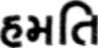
હમતિ
